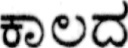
ಕಾಲದ
